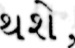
થશે,
